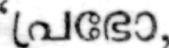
‘പ്രഭോ,
